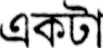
একটা
